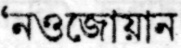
‘নওজোয়ান
